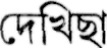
দেখিছা
